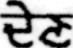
ਦੇਣ
